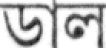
ডাল
